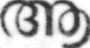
ആ
